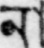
না
